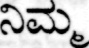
ನಿಮ್ಮ
